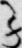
કે
